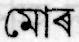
মোৰ
